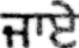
ਜਾਏ
